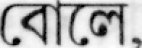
বোলে,
